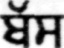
ਬੱਸ
